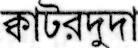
ক্বাটরদুদা
